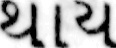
થાય
